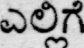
ಎಲ್ಲಿಗೆ
